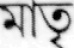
মাতৃ
